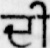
ਦੀ
